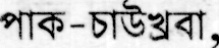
পাক-চাউখ্রবা,
